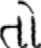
તો
